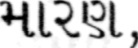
મારણ,
